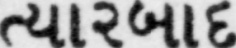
ત્યારબાદ
